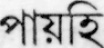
পায়হি
